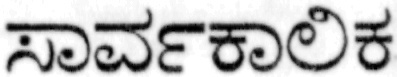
ಸಾರ್ವಕಾಲಿಕ
